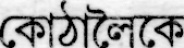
কোঠালৈকে
